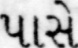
પાસે
